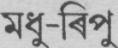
মধু-ৰিপু
